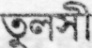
তুলসী
